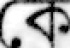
কে.
